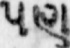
પણ
